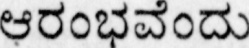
ಆರಂಭವೆಂದು
